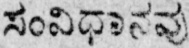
ಸಂವಿಧಾನವು
